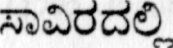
ಸಾವಿರದಲ್ಲಿ
